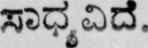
ಸಾಧ್ಯವಿದೆ.
